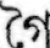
গৈ
